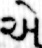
એ
